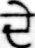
ਦੇ
